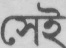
সেই
